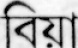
বিয়া
